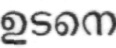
ഉടനെ
